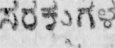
ಸರಕುಗಳ
